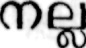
നല്ല
